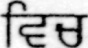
ਵਿਚ
